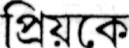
প্রিয়কে
